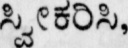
ಸ್ವೀಕರಿಸಿ,
